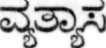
ವ್ಯತ್ಯಾಸ
